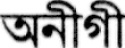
অনীগী
